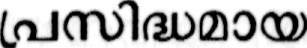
പ്രസിദ്ധമായ
